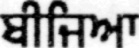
ਬੀਜਿਆ
